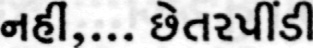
નહીં,.......છેતરપીંડી
